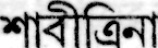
শাবীত্রিনা
